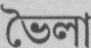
ভৈলা
